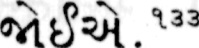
જોઈએ.૧૩૩
